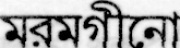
মরমগীনো
